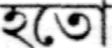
হতো
